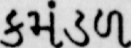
કમંડળ
